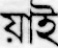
য়াই
